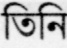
তিনি
